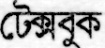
টেক্সবুক
